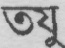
তযু
